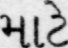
માટે
